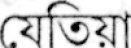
যেতিয়া
